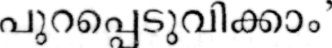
പുറപ്പെടുവിക്കാം'
